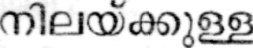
നിലയ്ക്കുള്ള
